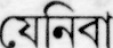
যেনিবা
